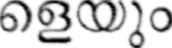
ളെയും
